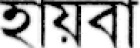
হায়বা
